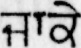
ਜਾਕੇ
